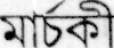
মার্চকী
